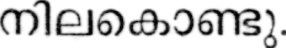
നിലകൊണ്ടു.
